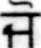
ਜੋ
